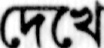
দেখে
